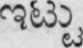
ಇಟ್ಟು
